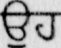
ਉਹ
